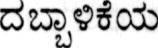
ದಬ್ಬಾಳಿಕೆಯ
